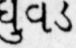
ઘુવડ
